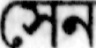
সেন
